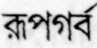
রূপগর্ব
